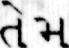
તેમ
